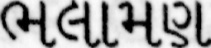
ભલામણ
